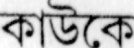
কাউকে
